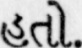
હતો.
